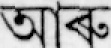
আৰু
